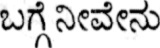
ಬಗ್ಗೆನೀವೇನು
